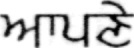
ਆਪਣੇ
